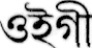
ওইগী
